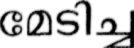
മേടിച്ച
